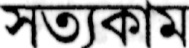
সত্যকাম
